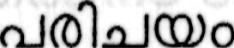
പരിചയം
